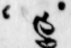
'હું
